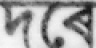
দৰে
